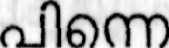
പിന്നെ
